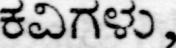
ಕವಿಗಳು,
